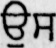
ਉਸ
